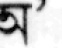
অ'
